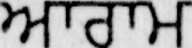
ਆਰਾਮ
